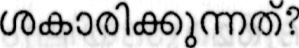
ശകാരിക്കുന്നത്?
